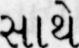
સાથે
